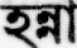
হন্না
